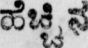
ಹೆಚ್ಚಿನ
